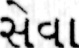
સેવા
